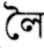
লৈ
